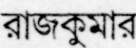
রাজকুমার
